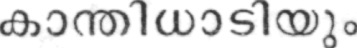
കാന്തിധാടിയും
